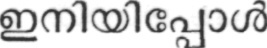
ഇനിയിപ്പോള്‍
